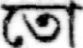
তো
